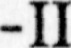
-II
